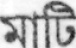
মাটি
